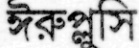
ঈরুপ্লুসি
